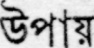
উপায়
